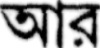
আর
